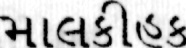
માલકીહક
